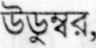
উডুম্বর,
